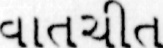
વાતચીત
